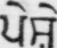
ਪੇਸ਼ੇ
